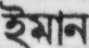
ইমান
